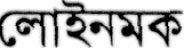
লোইনমক
